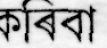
কৰিবা
